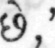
છે',
